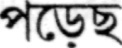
পড়েছ
